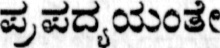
ಪ್ರಪದ್ಯಯಂತೇ
